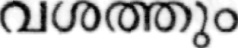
വശത്തും
